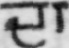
ਦਾ
